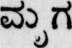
ಮೃಗ
